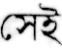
সেই
